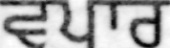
ਵਪਾਰ
